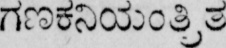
ಗಣಕನಿಯಂತ್ರಿತ
